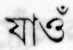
যাওঁ
